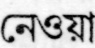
নেওয়া
